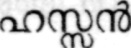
ഹസ്സന്‍
